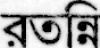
রতন্নি
